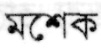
মশেক
